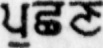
ਪੁਛਣ
